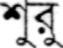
শুরু
